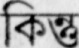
কিন্তু
